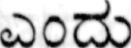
ಎಂದು
